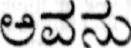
ಅವನು
